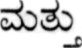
ಮತ್ತು
